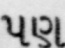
પણ
